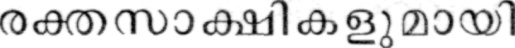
രക്തസാക്ഷികളുമായി
